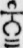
ਨੂੰ
